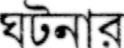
ঘটনার
